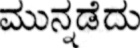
ಮುನ್ನಡೆದು
